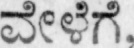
ವೇಳೆಗೆ,
